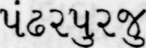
પંઢરપુરજુ
